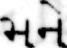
મને
